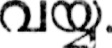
വയ്യ.
